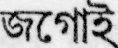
জগোই
